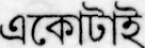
একোটাই
